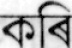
কৰি
